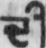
ਦੀ
